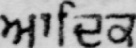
ਆਦਿਕ
